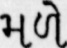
મળે
